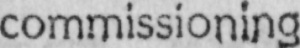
commissioning
